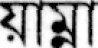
য়াম্না
